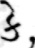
કે,
